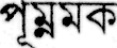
পূম্নমক
